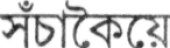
সঁচাকৈয়ে
